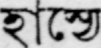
হাস্যে
